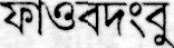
ফাওবদংবু
